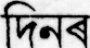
দিনৰ
